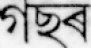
গছৰ
